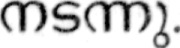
നടന്നു.
